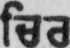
ਚਿਰ
